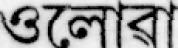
ওলোৱা
